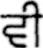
ਵੀ
